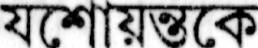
যশোয়ন্তকে
